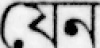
যেন
